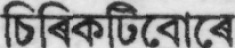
চিৰিকটিবোৰে
